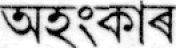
অহংকাৰ
